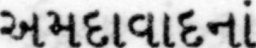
અમદાવાદનાં
